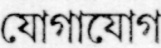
যোগাযোগ
